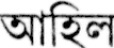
আহিল
